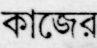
কাজের
